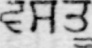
ਵਸਤੂ
